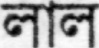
লাল
